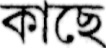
কাছে
